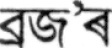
ব্রজ'ৰ
